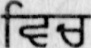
ਵਿਚ
